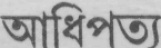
আধিপত্য
